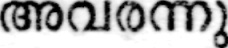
അവരന്നു
